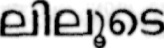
ലിലൂടെ
